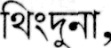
থিংদুনা,
